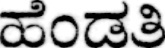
ಹೆಂಡತಿ
